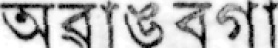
অৱাঙবগা
